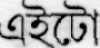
এইটো
